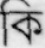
কি
